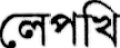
লেপখি
